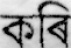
কৰি
